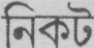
নিকট
